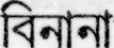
বিনানা
